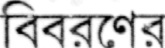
বিবরণের
